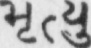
મૃત્યુ
